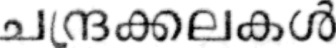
ചന്ദ്രക്കലകള്‍
